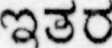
ಇತರ
